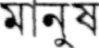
মানুষ
